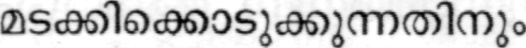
മടക്കിക്കൊടുക്കുന്നതിനും
